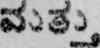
ಮತ್ತು
